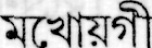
মখোয়গী
